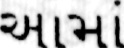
આમાં
